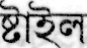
ষ্টাইল
